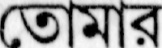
তোমার
